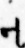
ન
